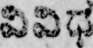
ವಿವಿಧ
